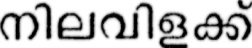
നിലവിളക്ക്
